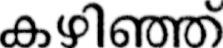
കഴിഞ്ഞ്
